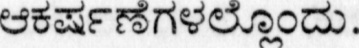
ಆಕರ್ಷಣೆಗಳಲ್ಲೊಂದು.
